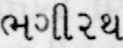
ભગીરથ
